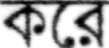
করে
